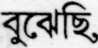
বুঝেছি,
